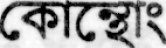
কোন্থোং
